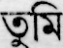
তুমি
